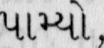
પામ્યો,
